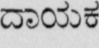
ದಾಯಕ
